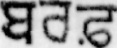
ਬਰਫ਼
